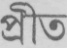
প্রীত
